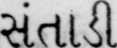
સંતાડી
